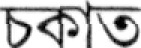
চকাত
